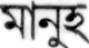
মানুহ
